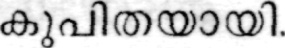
കുപിതയായി.
